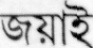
জয়াই
